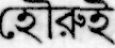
হৌরুই
